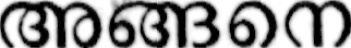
അങ്ങനെ
